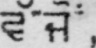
ਵੱਜੋਂ,
